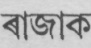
ৰাজাক
